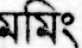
মমিং
